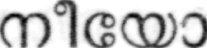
നീയോ
